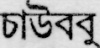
চাউববু
